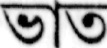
ভাত
